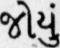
જોયું
